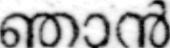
ഞാന്‍
